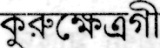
কুরুক্ষেত্রগী
